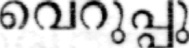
വെറുപ്പു
